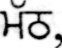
ਮੱਠ,
